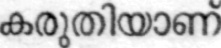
കരുതിയാണ്
